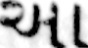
આ
